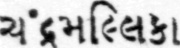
ચંદ્રમલ્લિકા
